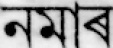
নমাৰ
